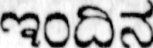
ಇಂದಿನ
